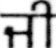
ਜੀ
